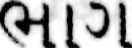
ભાગ
